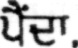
ਪੈਂਦਾ,
